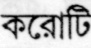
করোটি
